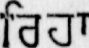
ਰਿਹਾ
